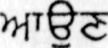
ਆਉਣ
